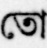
তো
